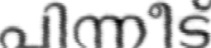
പിന്നീട്
